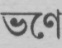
ভণে
